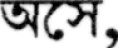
অসে,
